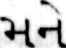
મને
